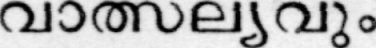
വാത്സല്യവും
